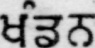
ਖੰਡਨ
